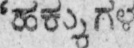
‘ಹಕ್ಕುಗಳ
